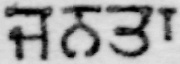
ਜਨਤਾ
